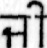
ਜੀ
